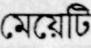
মেয়েটি
